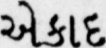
એકાદ
